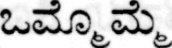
ಒಮ್ಮೊಮ್ಮೆ
